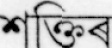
শক্তিৰ
